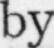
by
